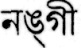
নঙগী
